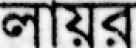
লায়র
